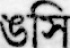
ঙসি
